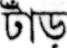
টাঁড়
